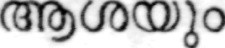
ആശയും
